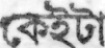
কেইটা
